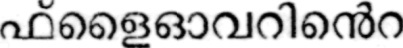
ഫ്ളൈഓവറിന്റെ
